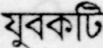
যুবকটি
